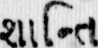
શાન્તિ
